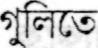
গুলিতে
